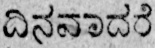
ದಿನವಾದರೆ
